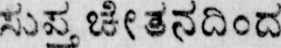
ಸುಪ್ತಚೇತನದಿಂದ
